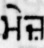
ਮੇਜ਼
